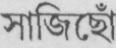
সাজিছোঁ
